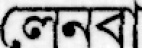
লেনবা
